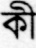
কী
